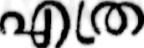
എത്ര
